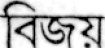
বিজয়
